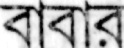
বাবার
